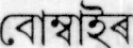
বোম্বাইৰ
